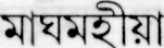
মাঘমহীয়া
